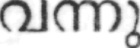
വന്നു
